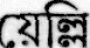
য়েল্লি
